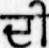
ਦੀ
